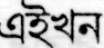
এইখন
